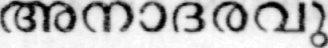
അനാദരവു
